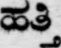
ಹತ್ತಿ
